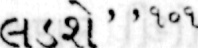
લડશે."૧૦૧
